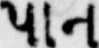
પાન
